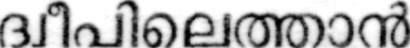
ദ്വീപിലെത്താന്‍
